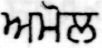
ਅਮੋਲ
